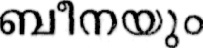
ബീനയും
